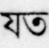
যত
